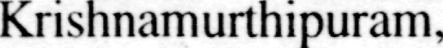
Krishnamurthipuram,
